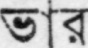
ভার
